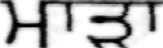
ਮਾੜਾ
